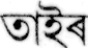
তাইৰ
